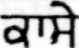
ਕਾਸੇ
